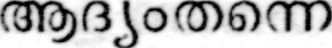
ആദ്യംതന്നെ
